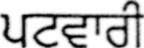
ਪਟਵਾਰੀ
